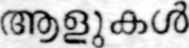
ആളുകള്‍
